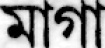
মাগা
